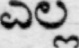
ಎಲ್ಲ
